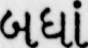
બધાં
